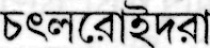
চৎলরোইদরা
